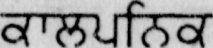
ਕਾਲਪਨਿਕ
